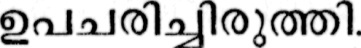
ഉപചരിച്ചിരുത്തി.
